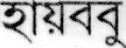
হায়ববু
